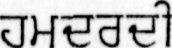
ਹਮਦਰਦੀ
